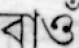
বাওঁ
